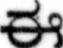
ಈ
